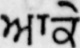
ਆਕੇ
